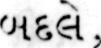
બદલે,
